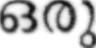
ഒരു
